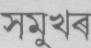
সমুখৰ
